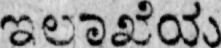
ಇಲಾಖೆಯ
